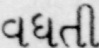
વધતી
